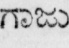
ಗಾಜು
